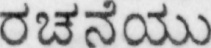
ರಚನೆಯು
